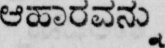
ಆಹಾರವನ್ನು
